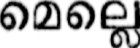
മെല്ലെ
